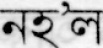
নহ'ল
